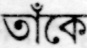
তাঁকে
